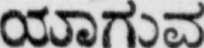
ಯಾಗುವ
